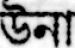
উনা
